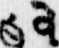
હવે
